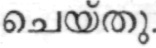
ചെയ്തു.
